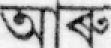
আৰু
